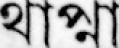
থাপ্না
